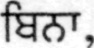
ਬਿਨਾ,
